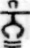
ਨੂੰ
